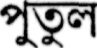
পুতুল
